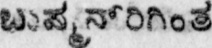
ಬುಷ್ಮನ್ರಿಗಿಂತ
